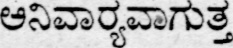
ಅನಿವಾರ್ಯವಾಗುತ್ತ
